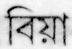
বিয়া
